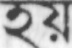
হয়
